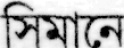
সিমানে
